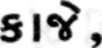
કાજે,
